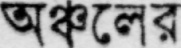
অঞ্চলের
